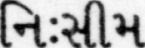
નિઃસીમ
